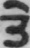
ਤੇ
